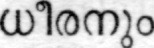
ധീരനും
